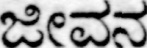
ಜೀವನ
